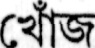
খোঁজ
